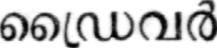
ഡ്രൈവര്‍
